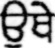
ਉਥੇ
